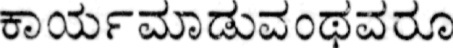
ಕಾರ್ಯಮಾಡುವಂಥವರೂ
